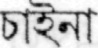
চাইনা
